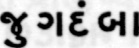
જુગદંબા
